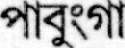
পাবুংগা
